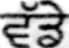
ਵੱਡੇ
